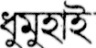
ধুমুহাই
